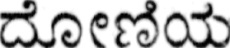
ದೋಣಿಯ
